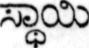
ಸ್ಥಾಯಿ
